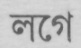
লগে
